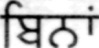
ਬਿਨਾਂ
